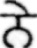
ਨੇ
